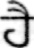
ਹੈ
